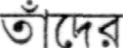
তাঁদের
